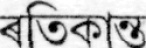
ৰতিকান্ত
